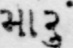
મારું
